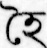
হৈ
